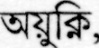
অয়ুক্নি,
